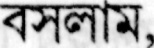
বসলাম,
